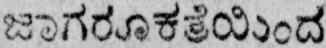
ಜಾಗರೂಕತೆಯಿಂದ
